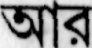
আর
